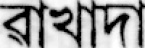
ৱাখাদা
